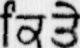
ਕਿਤੇ
